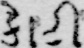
કોટી
